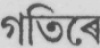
গতিৰে
